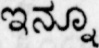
ಇನ್ನೂ
